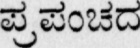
ಪ್ರಪಂಚದ
